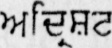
ਅਦ੍ਰਿਸ਼ਟ
